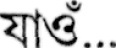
যাওঁ...
